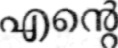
എന്റെ
